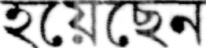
হয়েছেন
